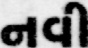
નવી
